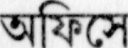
অফিসে
